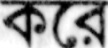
করে
